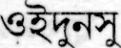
ওইদুনসু
